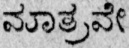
ಮಾತ್ರವೇ
